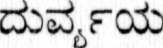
ದುರ್ವ್ಯಯ
